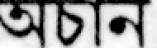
অচান
